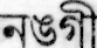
নঙগী
